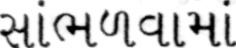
સાંભળવામાં
